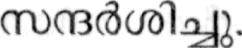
സന്ദര്‍ശിച്ചു.
